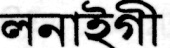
লনাইগী
